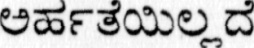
ಅರ್ಹತೆಯಿಲ್ಲದೆ
